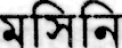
মসিনি
